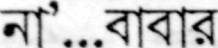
না’....বাবার
